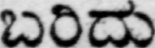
ಬರಿದು
